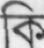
কি
